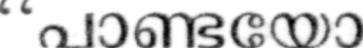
"പാണ്ടയോ
